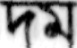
দম
